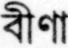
বীণা
